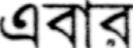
এবার
